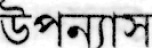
উপন্যাস
